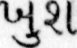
ખુશ
